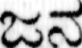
ಜನ
